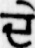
ਦੇ
